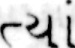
ત્યાં
